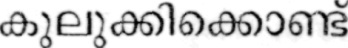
കുലുക്കിക്കൊണ്ട്
